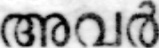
അവര്‍
